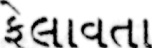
ફેલાવતા
